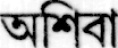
অশিবা
